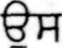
ਉਸ
